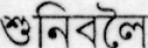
শুনিবলৈ
